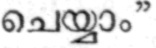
ചെയ്യാം”
